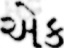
એક
